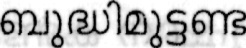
ബുദ്ധിമുട്ടണ്ട
